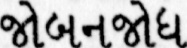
જોબનજોધ
